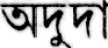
অদুদা
